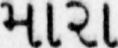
મારા
